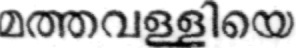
മത്തവള്ളിയെ
